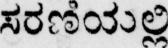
ಸರಣಿಯಲ್ಲಿ
